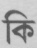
কি
